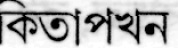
কিতাপখন
